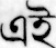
এই
